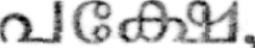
പക്ഷേ,
